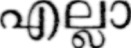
എല്ലാ
